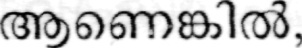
ആണെങ്കില്‍,
